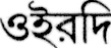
ওইরদি
